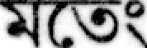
মতেং
